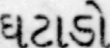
ઘટાડો
